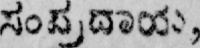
ಸಂಪ್ರದಾಯ,
